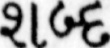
શબ્દ
